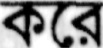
করে
